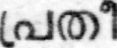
പ്രതീ
